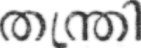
തന്ത്രി
